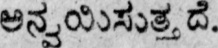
ಅನ್ವಯಿಸುತ್ತದೆ.
